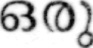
ഒരു
